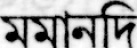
মমানদি
